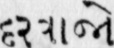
દરવાજો
